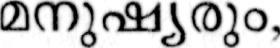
മനുഷ്യരും,
